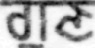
ਗੁਣ
